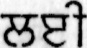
ਲਈ
